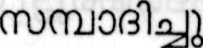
സമ്പാദിച്ചു
